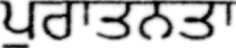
ਪੁਰਾਤਨਤਾ
